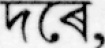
দৰে,
